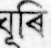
ঘূৰি
